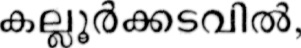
കല്ലൂര്‍ക്കടവില്‍,
